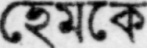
হেমকে
